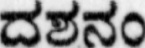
ದಶನಂ
